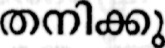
തനിക്കു
